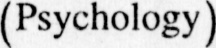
(Psychology)
